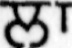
ਲਾ
